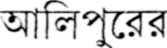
আলিপুরের
